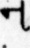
ન
